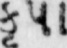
કૃપા
